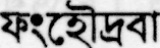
ফংহৌদ্রবা
